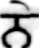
ਨੇ
